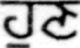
ਹੁਣ
